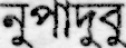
নুপাদুবু
